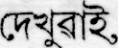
দেখুৱাই,
